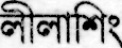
লীলাশিং
